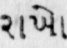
રાખો
